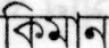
কিমান
